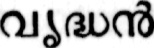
വൃദ്ധന്‍
